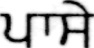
ਪਾਸੇ
